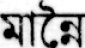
মান্নৈ
